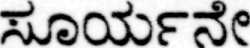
ಸೂರ್ಯನೇ
